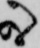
જે
